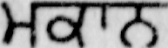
ਮਕਾਨ
